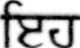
ਇਹ
